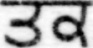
ਤਕ
